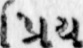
પ્રિય
